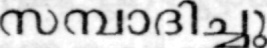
സമ്പാദിച്ചു
